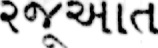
રજૂઆત
